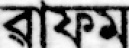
ৱাফম
